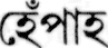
হেঁপাহ
